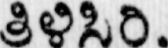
ತಿಳಿಸಿರಿ.
